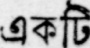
একটি
